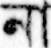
না
